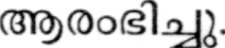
ആരംഭിച്ചു.
